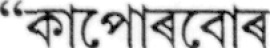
"কাপোৰবোৰ
